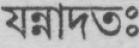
যন্নাদতঃ
